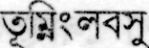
তূম্নিংলবসু
